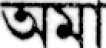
অমা
